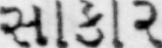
સાકાર
